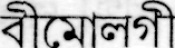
বীমোলগী
